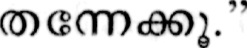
തന്നേക്കൂ.”
